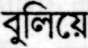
বুলিয়ে
